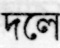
দলে
